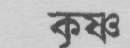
কৃষ্ণ
